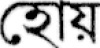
হোয়
